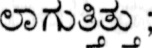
ಲಾಗುತ್ತಿತ್ತು;
